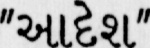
"આદેશ"
